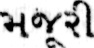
મજૂરી
